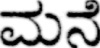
ಮನೆ
